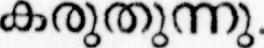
കരുതുന്നു.
